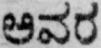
ಅವರ
